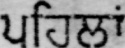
ਪਹਿਲਾਂ
